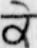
ਕੇ
